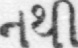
નથી
